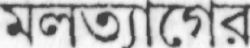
মলত্যাগের
